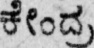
ಕೇಂದ್ರ
